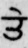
ਤੇ
